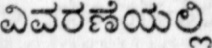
ವಿವರಣೆಯಲ್ಲಿ
